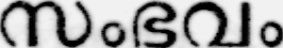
സംഭവം
